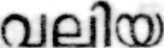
വലിയ
